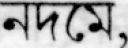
নদমে,
